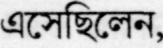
এসেছিলেন,
